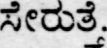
ಸೇರುತ್ತೆ.
